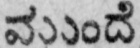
ಮುಂದೆ
